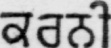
ਕਰਨੀ
